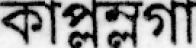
কাপ্লম্লগা
